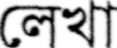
লেখা
